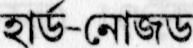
হার্ড-নোজড
